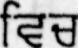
ਵਿਚ
